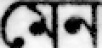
মেন
